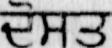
ਦੋਸਤ
